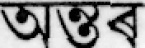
অন্তৰ
